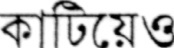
কাটিয়েও
